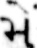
મેં
